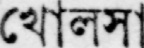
খোলসা
